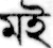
মই
